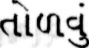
તોળવું
